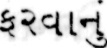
ફરવાનું
